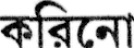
করিনো
